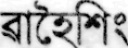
ৱাহৈশিং
